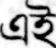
এই
